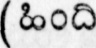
(ಹಿಂದಿ
